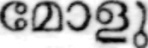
മോളു
